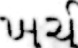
ખર્ચ
